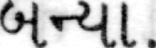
બન્યા.
